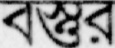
বস্তুর
